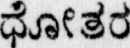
ಧೋತರ
